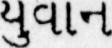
યુવાન
